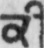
ਕੀ
